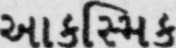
આકસ્મિક
